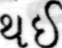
થઈ
